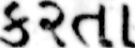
કરતા
